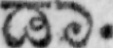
ಡಾ.
